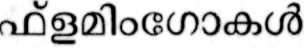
ഫ്ളമിംഗോകള്‍
